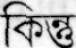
কিন্তু
